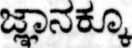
ಜ್ಞಾನಕ್ಕೂ
